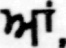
ਆਂ,
